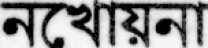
নখোয়না
